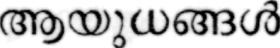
ആയുധങ്ങള്‍
